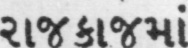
રાજકાજમાં
